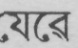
যেৱে
